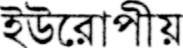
ইউরোপীয়
